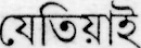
যেতিয়াই
